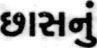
છાસનું
